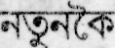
নতুনকৈ
